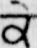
ਕੇ
